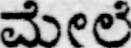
ಮೇಲೆ
